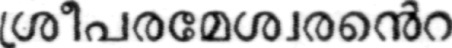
ശ്രീപരമേശ്വരന്റെ
